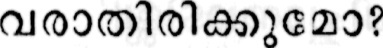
വരാതിരിക്കുമോ?
